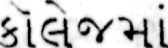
કોલેજમાં
